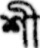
শী
